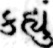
કહ્યું
